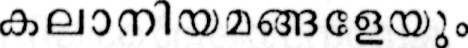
കലാനിയമങ്ങളേയും
